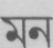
মন
